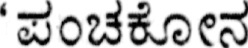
'ಪಂಚಕೋನ
